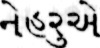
નેહરુએ
